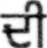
ਦੀ
